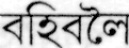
বহিবলৈ
